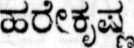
ಹರೇಕೃಷ್ಣ
